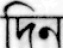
দিন
